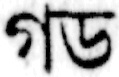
গড
